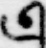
এ
